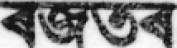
ৰজতৰ
